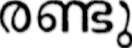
രണ്ടു
